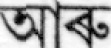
আৰু
